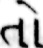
તો
